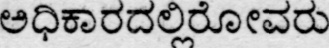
ಅಧಿಕಾರದಲ್ಲಿರೋವರು
